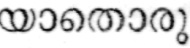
യാതൊരു
